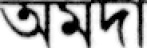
অমদা
